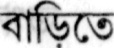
বাড়িতে
